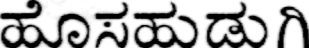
ಹೊಸಹುಡುಗಿ
